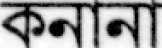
কনানা
